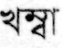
খম্বা
